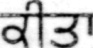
ਕੀਤਾ
